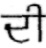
ਦੀ
